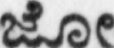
ಜೋ
